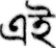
এই
